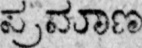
ಪ್ರಮಾಣ
